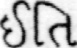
ઈતિ
